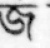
জি
